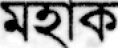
মহাক
